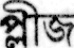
প্লীজ
